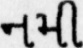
નમી
